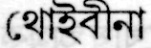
থোইবীনা
